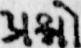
પ્રશ્નો
